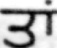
ਤਾਂ
